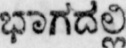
ಭಾಗದಲ್ಲಿ
